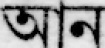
আন
